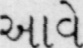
આવે
